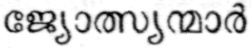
ജ്യോത്സ്യന്മാര്‍
